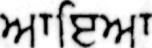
ਆਇਆ
